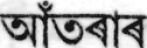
আঁতৰাৰ
